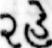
રહે
